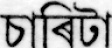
চাৰিটা
